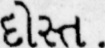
દોસ્ત.
